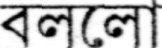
বললো
